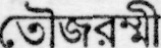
তৌজরম্মী
